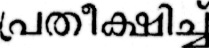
പ്രതീക്ഷിച്ച്
